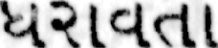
ધરાવતા
